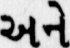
અને
